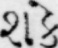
શકે
